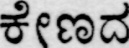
ಕೇಣದ
